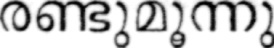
രണ്ടുമൂന്നു
